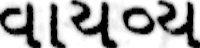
વાયવ્ય
